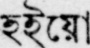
হইয়ো
